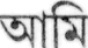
আমি
